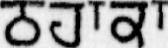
ਠਹਾਕਾ
